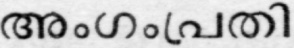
അംഗംപ്രതി
